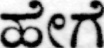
ಹೇಗೆ
